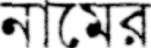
নামের
